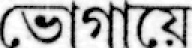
ভোগায়ে
